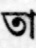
তা
